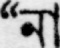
‘‘না
